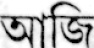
আজি
